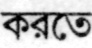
করতে
